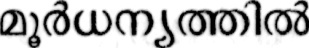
മൂര്‍ധന്യത്തില്‍
